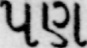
પણ
